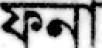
ফনা
